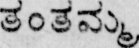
ತಂತಮ್ಮ
